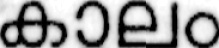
കാലം
